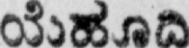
ಯೆಹೂದಿ
